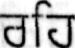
ਰਹਿ
